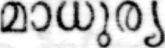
മാധുര്യ
